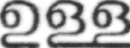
ഉള്ള
